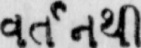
વર્તનથી
